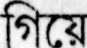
গিয়ে
